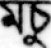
মচু
